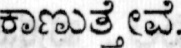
ಕಾಣುತ್ತೇವೆ.
